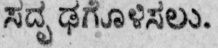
ಸದೃಢಗೊಳಿಸಲು.
